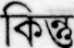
কিন্তু
